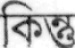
কিন্তু
